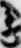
કે
